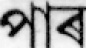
পাৰ
